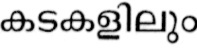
കടകളിലും
